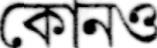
কোনও
